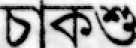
চাকশু
